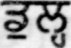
ਡੁਲ੍ਹ
